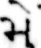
મેં
